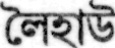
লৈহাউ
